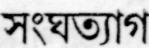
সংঘত্যাগ
